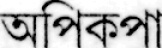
অপিকপা
